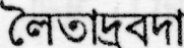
লৈতাদ্রবদা
